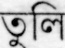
তুলি
